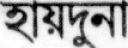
হায়দুনা
